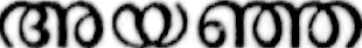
അയഞ്ഞ
